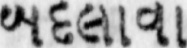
બદલાવા
